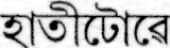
হাতীটোৱে
